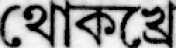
থোকখ্রে
